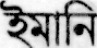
ইমানি
